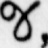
જ,
